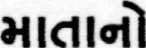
માતાનો
